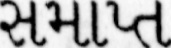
સમાપ્ત
